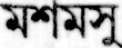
মশমসু
